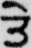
ਤੇ
